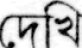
দেখি
